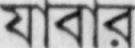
যাবার
